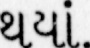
થયાં.
